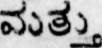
ಮತ್ತು
